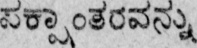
ಪಕ್ಷಾಂತರವನ್ನು
